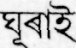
ঘূৰাই
